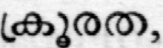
ക്രൂരത,
